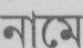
নামে
